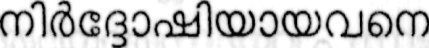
നിര്‍ദ്ദോഷിയായവനെ
